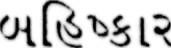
બહિષ્કાર
